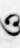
ও
